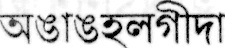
অঙাঙহলগীদা
